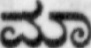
ಮಾ
